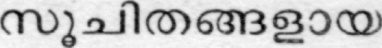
സൂചിതങ്ങളായ
